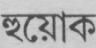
হুয়োক
